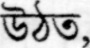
উঠত,
